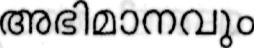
അഭിമാനവും
